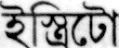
ইস্ত্রিটো
